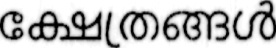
ക്ഷേത്രങ്ങള്‍
